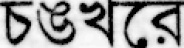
চঙখরে
